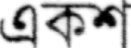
একশ
